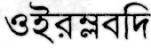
ওইরম্লবদি
